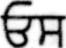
ਓਸ
